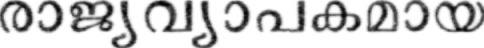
രാജ്യവ്യാപകമായ
